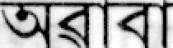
অৱাবা
